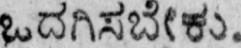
ಒದಗಿಸಬೇಕು.
